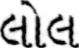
લોલ
